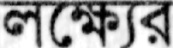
লক্ষ্যের
